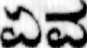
ಏವ
